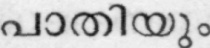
പാതിയും
